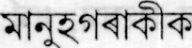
মানুহগৰাকীক
